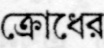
ক্রোধের
